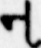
ન
